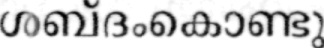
ശബ്ദംകൊണ്ടു
